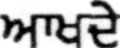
ਆਖਦੇ
